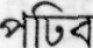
পঢ়িব
